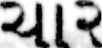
ચાર
